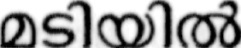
മടിയില്‍
